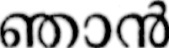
ഞാന്‍
